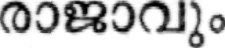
രാജാവും
